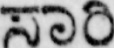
ಸಾರಿ
